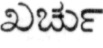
ಖರ್ಚು
